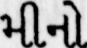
મીનો
